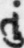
તું
